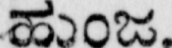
ಹುಂಜ.
